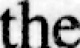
the
